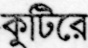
কুটিরে
